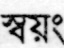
স্বয়ং
